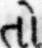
તો
